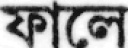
ফালে
